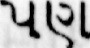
પણ
